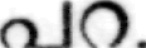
പറ.
